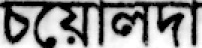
চয়োলদা
